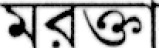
মরক্তা
